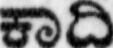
ಕಾದಿ
